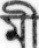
মী
